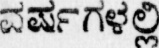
ವರ್ಷಗಳಲ್ಲಿ
